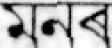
মনৰ
